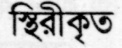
স্থিরীকৃত
